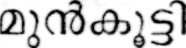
മുന്‍കൂട്ടി
